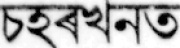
চহৰখনত
